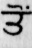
ਤੋਂ
